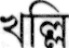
খল্লি
